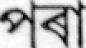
পৰা
